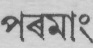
পৰমাং
